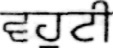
ਵਹੁਟੀ
